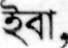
ইবা,
